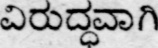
ವಿರುದ್ಧವಾಗಿ
